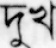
দুখ
